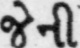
જેની
